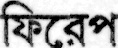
ফিরেপ
